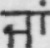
ਜਾਂ
